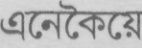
এনেকৈয়ে
